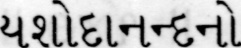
યશોદાનન્દનો
